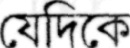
যেদিকে
